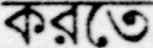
করতে
